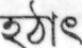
হঠাৎ
